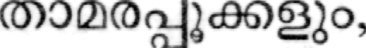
താമരപ്പൂക്കളും,
